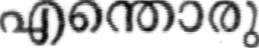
എന്തൊരു
